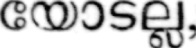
യോടല്ല,
